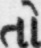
તો
